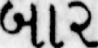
બાર
